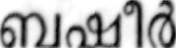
ബഷീര്‍
